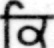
ਕਿ
